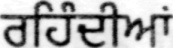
ਰਹਿੰਦੀਆਂ
